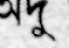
অদু
